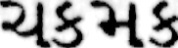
ચકમક
